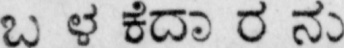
ಬಳಕೆದಾರನು
